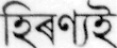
হিৰণ্যই
